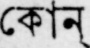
কোন্
